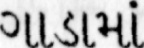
ગાડામાં
